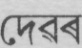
দেৱৰ
